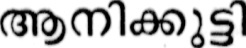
ആനിക്കുട്ടി
